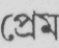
প্ৰেম
